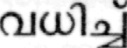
വധിച്ച്
